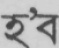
হ'ব
